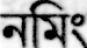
নমিং
